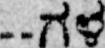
--ಗಳ
